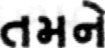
તમને
